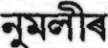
নুমলীৰ
